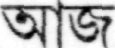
আজ
